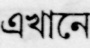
এখানে
